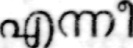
എന്നീ
